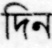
দিন
